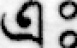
এঃ
